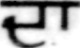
ਦਾ
